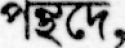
পন্থদে,
